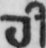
ਹੀ
